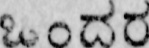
ಒಂದರ
